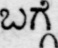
ಬಗ್ಗೆ
